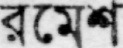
রমেশ
